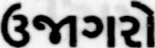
ઉજાગરો
